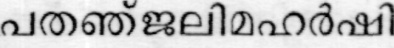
പതഞ്ജലിമഹര്‍ഷി
